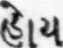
હોય
